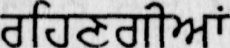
ਰਹਿਣਗੀਆਂ
